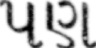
પણ
